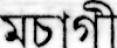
মচাগী
